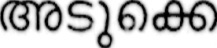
അടുക്കെ
